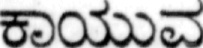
ಕಾಯುವ
